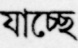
যাচ্ছে
